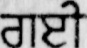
ਗਈ
